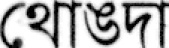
থোঙদা
